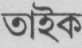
তাইক
